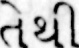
તેથી
